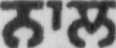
ਨਾਲ
